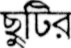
ছুটির
